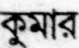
কুমার
